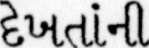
દેખતાંની
